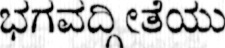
ಭಗವದ್ಗೀತೆಯು
